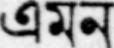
এমন
